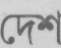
দেশ
